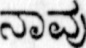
ನಾವು
